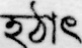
হঠাৎ
